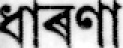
ধাৰণা
